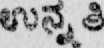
ಉನ್ನತಿ
